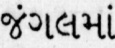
જંગલમાં
